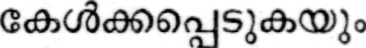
കേള്‍ക്കപ്പെടുകയും
